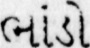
ભાંડો
